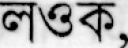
লওক,
